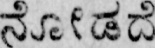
ನೋಡದೆ
